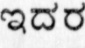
ಇದರ
